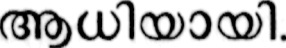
ആധിയായി.
